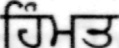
ਹਿੰਮਤ
